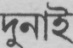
দুনাই
